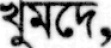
খুমদে,
